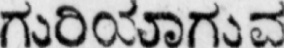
ಗುರಿಯಾಗುವ
